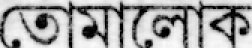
তোমালোক
